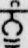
ਨੂੰ
